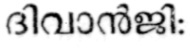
ദിവാന്‍ജി:
